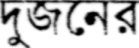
দুজনের
